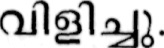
വിളിച്ചു.
